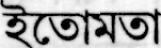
ইতোমতা
